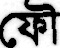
ফৌ
